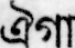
ঐগা
